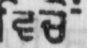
ਵਿਚੋਂ
